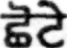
ਛੋਟੇ
